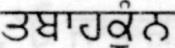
ਤਬਾਹਕੁੰਨ
